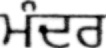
ਮੰਦਰ
